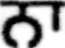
ਨਾ
